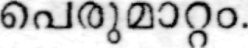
പെരുമാറ്റം.
